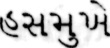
હસમુખે
